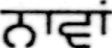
ਨਾਵਾਂ
